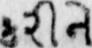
કરીને
